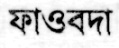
ফাওবদা
